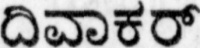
ದಿವಾಕರ್
